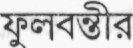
ফুলবন্তীর
